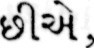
છીએ,
